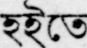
হইতে
